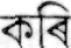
কৰি
